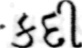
કદી
